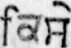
ਕਿਸੇ
